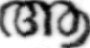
ആ
